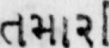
તમારાં
